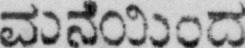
ಮನೆಯಿಂದ
